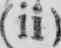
(ii)
